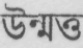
উন্মত্ত
